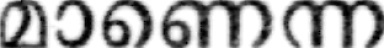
മാണെന്ന
